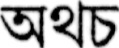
অথচ
